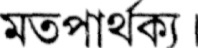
মতপার্থক্য।
